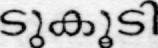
ടുകൂടി
